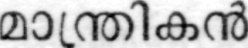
മാന്ത്രികന്‍
